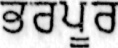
ਭਰਪੂਰ
